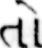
તો
